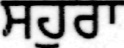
ਸਹੁਰਾ
